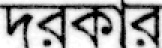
দরকার
